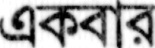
একবার
